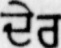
ਦੇਰ
